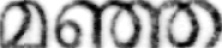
മഞ്ഞ
